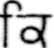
ਕਿ
